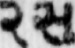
રસ
